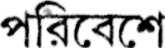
পরিবেশে
